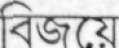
বিজয়ে
